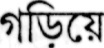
গড়িয়ে
